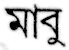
মাবু
